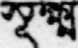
সূক্ষ্ম
